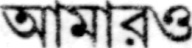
আমারও
